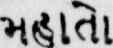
મહાતો
